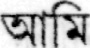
আমি
